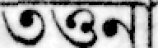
তত্তনা
